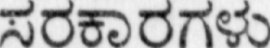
ಸರಕಾರಗಳು
